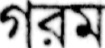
গরম
